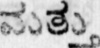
ಮತ್ತು
